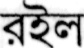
রইল
